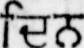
ਦਿਨ
